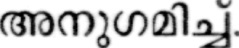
അനുഗമിച്ച്.
